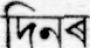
দিনৰ
